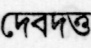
দেবদত্ত
